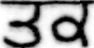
ਤਕ
